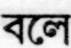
বলে
